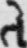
તે
